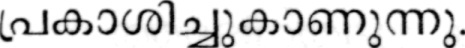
പ്രകാശിച്ചുകാണുന്നു.
